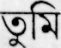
তুমি
